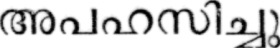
അപഹസിച്ചു
